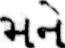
મને
